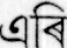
এৰি
